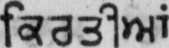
ਕਿਰਤੀਆਂ
